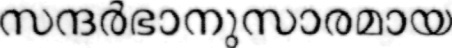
സന്ദര്‍ഭാനുസാരമായ
